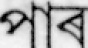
পাৰ
